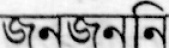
জনজননি
